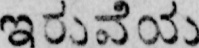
ಇರುವೆಯ
